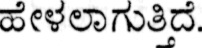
ಹೇಳಲಾಗುತ್ತಿದೆ.
